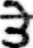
ਤੇ
